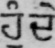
ਹੁੰਦੇ
